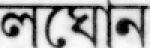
লঘোন
